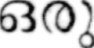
ഒരു
